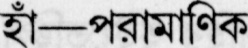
হাঁ-পরামাণিক
